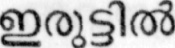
ഇരുട്ടില്‍
